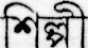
শিল্পী
